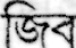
জিব
